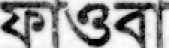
ফাওবা
